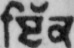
ਇੱਕ
